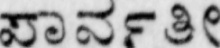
ಪಾರ್ವತೀ
